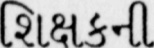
શિક્ષકની
